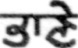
ਭਾਣੇ
